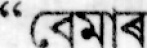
"বেমাৰ
